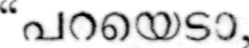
"പറയെടാ,
